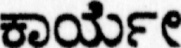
ಕಾರ್ಯೇ
